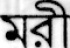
মরী
